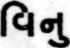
વિનુ
